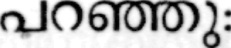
പറഞ്ഞു:
